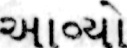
આવ્યો
